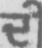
ਦੀ
